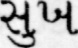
સુખ
